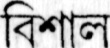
বিশাল
